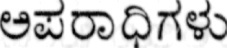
ಅಪರಾಧಿಗಳು
